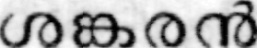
ശങ്കരന്‍
